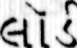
લૉર્ડ
